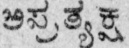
ಅಪ್ರತ್ಯಕ್ಷ
